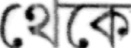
থেকে
